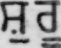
ਸ਼ੁਰੂ
